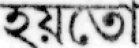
হয়তো
